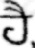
ਹੈ,
